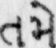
તમે
